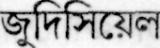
জুদিসিয়েল
